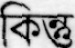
কিন্তু
